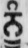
ਨੂੰ
